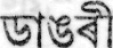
ডাঙৰী
